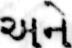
અને
